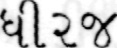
ધીરજ
